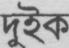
দুইক
